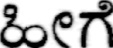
ಹೀಗೆ
